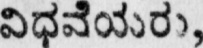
ವಿಧವೆಯರು,
